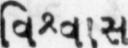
વિશ્વાસ
